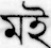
মই
